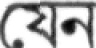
যেন
